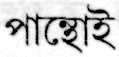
পান্থোই
